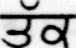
ਤੱਕ
